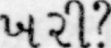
ખરી?
